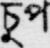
চুপ
